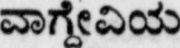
ವಾಗ್ದೇವಿಯ
